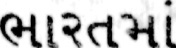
ભારતમાં
